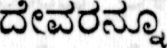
ದೇವರನ್ನೂ
